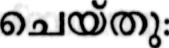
ചെയ്തു:
